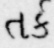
તર્ક
